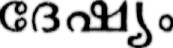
ദേഷ്യം
